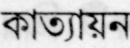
কাত্যায়ন
